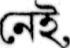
নেই,
